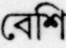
বেশি
